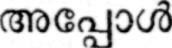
അപ്പോള്‍
